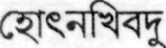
হোৎনখিবদু
